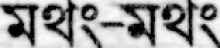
মথং-মথং
